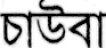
চাউবা
